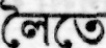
লৈতে
